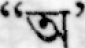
"অ'
